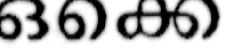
ഒക്കെ
